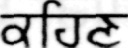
ਕਹਿਣ
